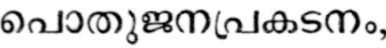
പൊതുജനപ്രകടനം,
